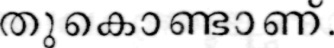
തുകൊണ്ടാണ്.
